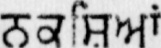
ਨਕਸ਼ਿਆਂ
